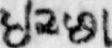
ઇચ્છા
